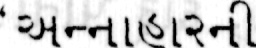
'અન્નાહારની
